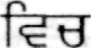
ਵਿਚ
